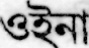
ওইনা
